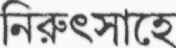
নিরুত্সাহে
